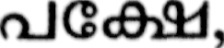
പക്ഷേ,
